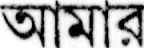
আমার
